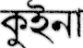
কুইনা
